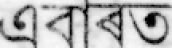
এবাৰত
